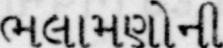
ભલામણોની
